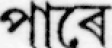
পাৰে
